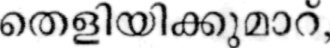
തെളിയിക്കുമാറ്,
